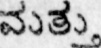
ಮತ್ತು
